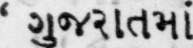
'ગુજરાતમાંં
